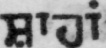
ਸ਼ਾਹਾਂ
